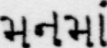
મનમાં
